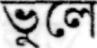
ভুলে
